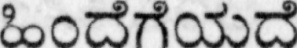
ಹಿಂದೆಗೆಯದೆ
